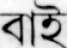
বাই
